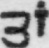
ਤਾਂ
